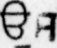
ਉਸ
